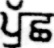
ਪੁੱਛ
